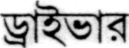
ড্রাইভার
